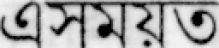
এসময়ত
